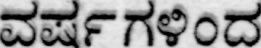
ವರ್ಷಗಳಿಂದ
